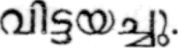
വിട്ടയച്ചു.
